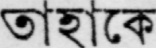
তাহাকে
